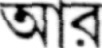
আর
